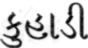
કુહાડી
